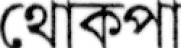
থোকপা
